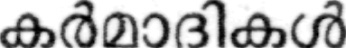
കര്‍മാദികള്‍
